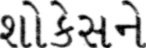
શોકેસને
